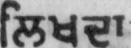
ਲਿਖਦਾ
